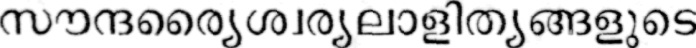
സൗന്ദര്യൈശ്വര്യലാളിത്യങ്ങളുടെ
